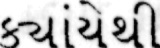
ક્યાંયેથી
